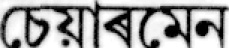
চেয়াৰমেন
